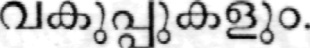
വകുപ്പുകളും.
